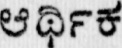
ಆರ್ಥಿಕ
